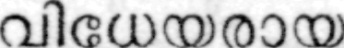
വിധേയരായ
